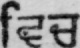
ਵਿਚ
